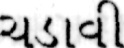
ચડાવી
